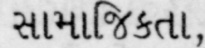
સામાજિકતા,
